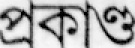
প্রকাণ্ড
